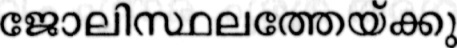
ജോലിസ്ഥലത്തേയ്ക്കു
